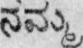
ನಮ್ಮ
